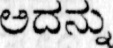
ಅದನ್ನು
